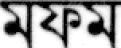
মফম
